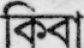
কিবা
